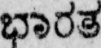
ಭಾರತ
